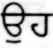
ਉਹ
